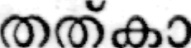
തത്കാ
